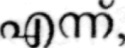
എന്ന്,
